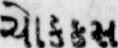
ચોક્કસ
